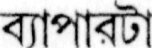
ব্যাপারটা
